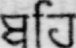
ਬਹਿ
